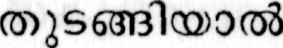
തുടങ്ങിയാല്‍
